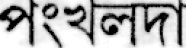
পংখলদা
